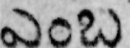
ಎಂಬ
